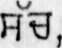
ਸੱਚ,
